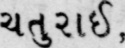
ચતુરાઈ,
